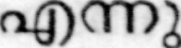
എന്നു
